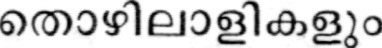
തൊഴിലാളികളും
